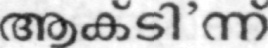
ആക്ടി'ന്ന്
